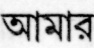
আমার
